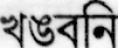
খঙবনি
